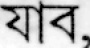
যাব,
